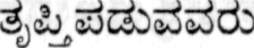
ತೃಪ್ತಿಪಡುವವರು
